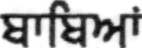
ਬਾਬਿਆਂ
